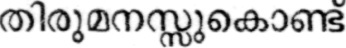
തിരുമനസ്സുകൊണ്ട്
